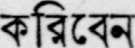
করিবেন
